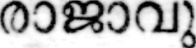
രാജാവു
